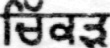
ਚਿੱਕੜ
